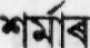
শর্মাৰ
